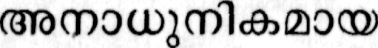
അനാധുനികമായ
